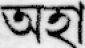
অহা
